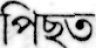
পিছত
